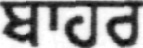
ਬਾਹਰ
